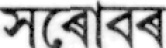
সৰোবৰ
